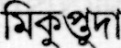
মিকুপ্তুদা
